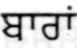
ਬਾਰਾਂ
